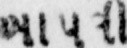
આપવી
